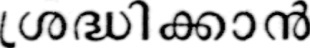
ശ്രദ്ധിക്കാന്‍
